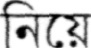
নিয়ে
